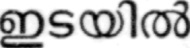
ഇടയില്‍
